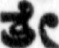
ತೇ
